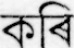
কৰি
